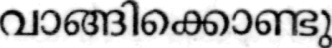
വാങ്ങിക്കൊണ്ടു
